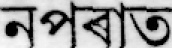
নপৰাত
